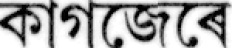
কাগজেৰে
